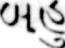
બહુ
